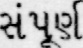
સંપૂર્ણ
